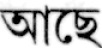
আছে
